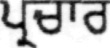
ਪ੍ਰਚਾਰ
